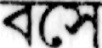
বসে
